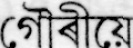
গৌৰীয়ে
